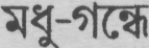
মধু-গন্ধে
